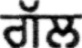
ਗੱਲ
